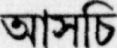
আসচি
